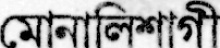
মোনালিশাগী
